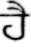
ਹੈ
